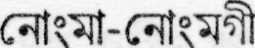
নোংমা-নোংমগী
